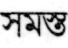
সমস্ত
